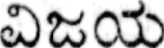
ವಿಜಯ
